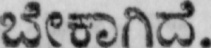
ಬೇಕಾಗಿದೆ.
